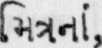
મિત્રનાં,
